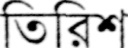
তিরিশ
